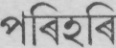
পৰিহৰি
